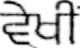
ਵੇਖੀਂ
